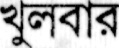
খুলবার
